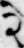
રે
